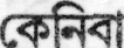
কেনিবা
